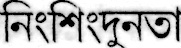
নিংশিংদুনতা
